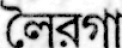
লৈরগা
